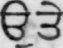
ਉਤੇ
